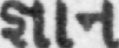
જ્ઞાન
